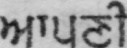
ਆਪਣੀ
